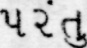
પરંતુ
